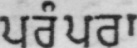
ਪਰੰਪਰਾ
